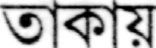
তাকায়
